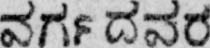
ವರ್ಗದವರ
